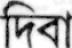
দিবা
